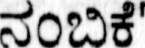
ನಂಬಿಕೆ’
